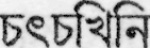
চৎচখিনি
